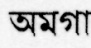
অমগা
